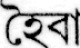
হৈবা
